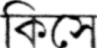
কিসে
